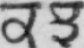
ਕਝ
